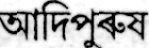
আদিপুৰুষ
